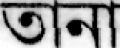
তানা
